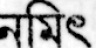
নমিৎ
